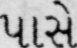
પાસે
